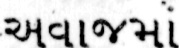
અવાજમાં
